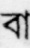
বা
